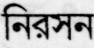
নিরসন
